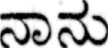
ನಾನು
